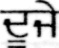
ਦੂਜੇ
